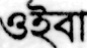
ওইবা
